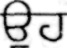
ਉਹ
